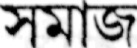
সমাজ
